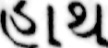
હાથ
